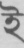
ই
